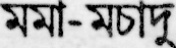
মমা-মচাদু
